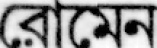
রোমেন
